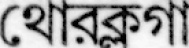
থোরক্লগা
